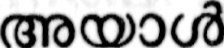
അയാള്‍
